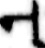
ન
